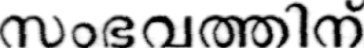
സംഭവത്തിന്
